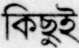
কিছুই
